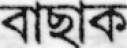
বাছাক
